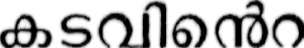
കടവിന്റെ
